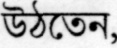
উঠতেন,
